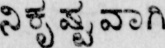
ನಿಕೃಷ್ಟವಾಗಿ
